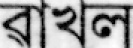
ৱাখল
